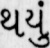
થયું
